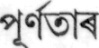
পূর্ণতাৰ
